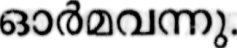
ഓര്‍മവന്നു.
